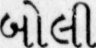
બોલી
